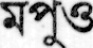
মপুও
